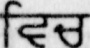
ਵਿਚ
